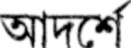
আদর্শে
